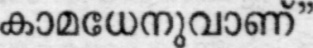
കാമധേനുവാണ്”
